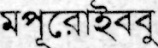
মপূরোইববু
